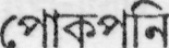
পোকপনি
